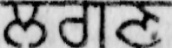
ਲਗਣ
